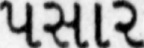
પસાર
